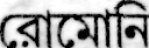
রোমোনি
